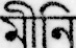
মীনি
